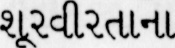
શૂરવીરતાના
